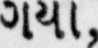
ગયા,
